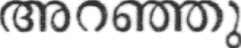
അറഞ്ഞു
